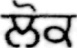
ਲੋਕ
